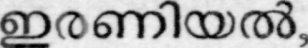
ഇരണിയല്‍,
